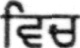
ਵਿਚ
